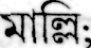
মাল্লি;
